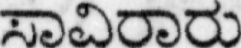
ಸಾವಿರಾರು
